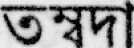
তম্বদা
